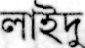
লাইদু
